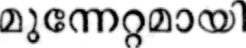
മുന്നേറ്റമായി
